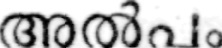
അല്‍പം
